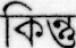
কিন্তু
